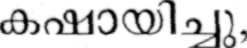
കഷായിച്ചു,
